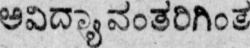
ಅವಿದ್ಯಾವಂತರಿಗಿಂತ
